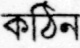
কঠিন
